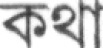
কথা
